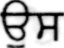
ਉਸ
